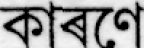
কাৰণে
